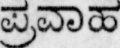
ಪ್ರವಾಹ
